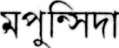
মপুন্সিদা
